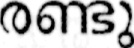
രണ്ടു
